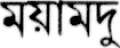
ময়ামদু
